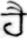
ਹੈ
